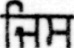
ਜਿਸ
